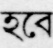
হবে
